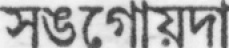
সঙগোয়দা
